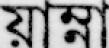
য়াম্না
